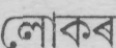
লোকৰ
